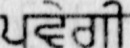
ਪਵੇਗੀ
